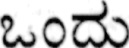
ಒಂದು
